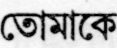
তোমাকে
